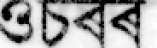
ওচৰৰ
